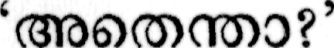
‘അതെന്താ?’
